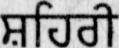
ਸ਼ਹਿਰੀ
